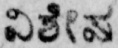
ವಿಶೇಷ
